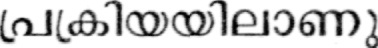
പ്രക്രിയയിലാണു
